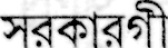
সরকারগী
